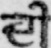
ਦੀ
